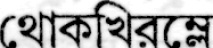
থোকখিরম্লে
